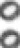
ঃ
